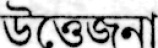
উত্তেজনা
